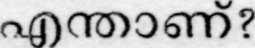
എന്താണ്?
